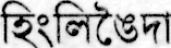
হিংলিঙৈদা
